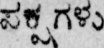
ಪಕ್ಷಗಳು
